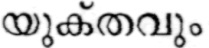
യുക്തവും
